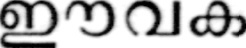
ഈവക
